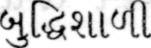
બુદ્ધિશાળી
